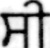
ਸੀ
